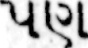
પણ
